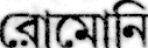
রোমোনি
